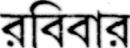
রবিবার
